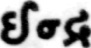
ઈન્દ્ર
